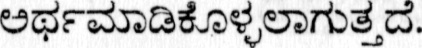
ಅರ್ಥಮಾಡಿಕೊಳ್ಳಲಾಗುತ್ತದೆ.
